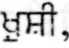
ਖ਼ੁਸ਼ੀ,
